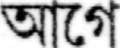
আগে
